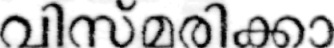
വിസ്മരിക്കാ
